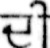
ਦੀ
